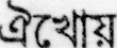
ঐখোয়
